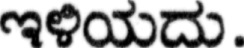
ಇಳಿಯದು.
